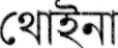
থোইনা
